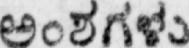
ಅಂಶಗಳು
